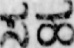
ಸಹ
